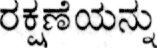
ರಕ್ಷಣೆಯನ್ನು
